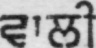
ਵਾਲੀ
